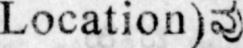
Location)ವು
